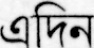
এদিন
